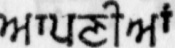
ਆਪਣੀਆਂ
